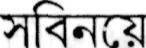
সবিনয়ে
